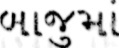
બાજુમાં
